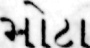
મોટા
